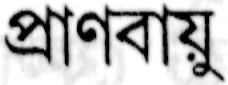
প্রাণবায়ু
